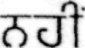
ਨਹੀਂ
